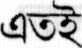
এতই
